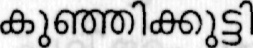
കുഞ്ഞിക്കുട്ടി
